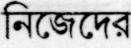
নিজেদের
